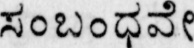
ಸಂಬಂಧವೇ
